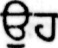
ਉਹ
